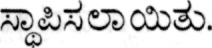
ಸ್ಥಾಪಿಸಲಾಯಿತು.
